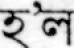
হ'ল
